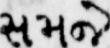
સમજે
